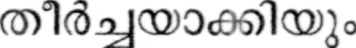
തീര്‍ച്ചയാക്കിയും
